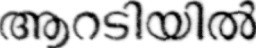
ആറടിയില്‍
